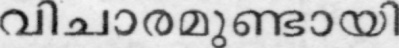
വിചാരമുണ്ടായി
